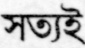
সত্যই
